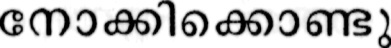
നോക്കിക്കൊണ്ടു
